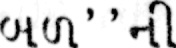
બળ"ની
